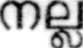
നല്ല
